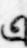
এ
